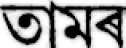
তামৰ
